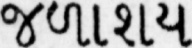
જળાશય
